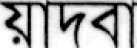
য়াদবা
